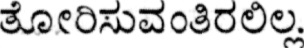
ತೋರಿಸುವಂತಿರಲಿಲ್ಲ.
